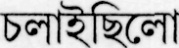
চলাইছিলো
